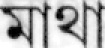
মাথা
